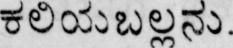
ಕಲಿಯಬಲ್ಲನು.
